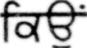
ਕਿਉਂ
